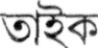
তাইক
